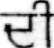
ਦੀ
